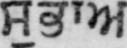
ਸੁਭਾਅ
